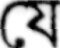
যে
